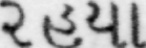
રહયા
